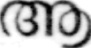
ആ
